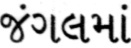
જંગલમાં
